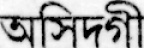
অসিদগী
